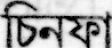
চিনফা
